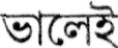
ভালেই
